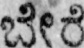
ಬೇರೆ
